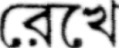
রেখে
